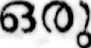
ഒരു
